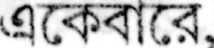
একেবারে,
